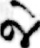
જે
